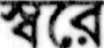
স্বরে
